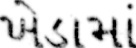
ખેડામાં
